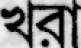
খরা
